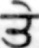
ਤੇ
